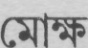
মোক্ষ
